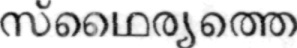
സ്ഥൈര്യത്തെ
